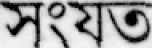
সংযত
